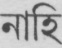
নাহি
